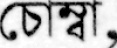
চোম্বা,
